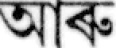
আৰু
